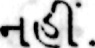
નહીં.
